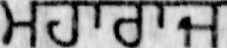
ਮਹਾਰਾਜ
